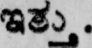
ಇತ್ತು.
